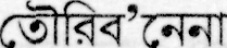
তৌরিব’নেনা
